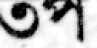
তপ
